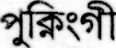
পুক্নিংগী
